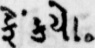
ફેંક્યો.
